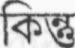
কিন্তু
